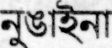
নুঙাইনা
